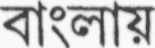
বাংলায়
